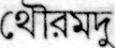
থৌরমদু
